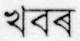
খবৰ
